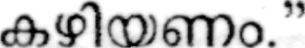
കഴിയണം.”
